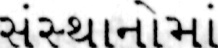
સંસ્થાનોમાં
